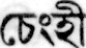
চেংহী
